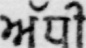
ਅੱਧੀ
